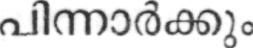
പിന്നാര്‍ക്കും
